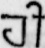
ਹੀ
